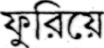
ফুরিয়ে
